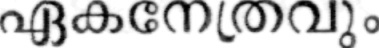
ഏകനേത്രവും
